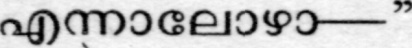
എന്നാലോഴാ-"
